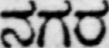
ನಗರ
